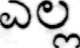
ಎಲ್ಲ
